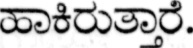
ಹಾಕಿರುತ್ತಾರೆ.
